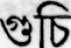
গুচি
